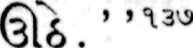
ઊઠે."૧૩૭
